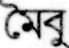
মৈবু
